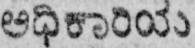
ಅಧಿಕಾರಿಯ
